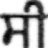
ਸੀ
